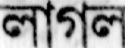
লাগল
